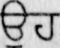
ਉਹ
